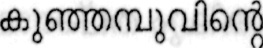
കുഞ്ഞമ്പുവിന്റെ
